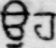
ਉਹ
